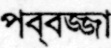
পব্বজ্জা
